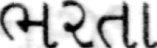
ભરતા
